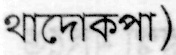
থাদোকপা)
